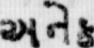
અનેક
